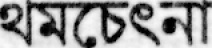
থমচেৎনা
